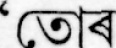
'তোৰ
